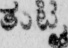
ತುಟ್ಟಿ
